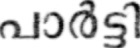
പാര്‍ട്ടി
